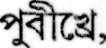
পুবীখ্রে,
